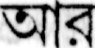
আর
